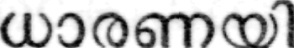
ധാരണയി
